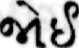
જોઈ
